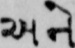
અને
